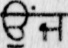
ਉਂਜ
